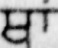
ਥਾਂ
